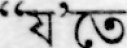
"য'তে
